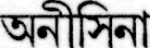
অনীসিনা
